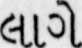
લાગે
